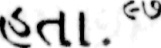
હતા.૯૭
